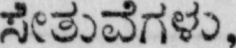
ಸೇತುವೆಗಳು,
